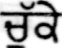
ਚੁੱਕੇ
